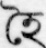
হৈ
